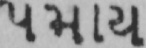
પમાય
